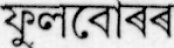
ফুলবোৰৰ
